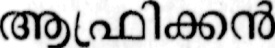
ആഫ്രിക്കന്‍
